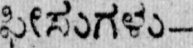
ಫೀಸುಗಳು-
